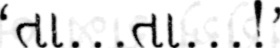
'તા...તા...!'
